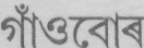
গাঁওবোৰ
